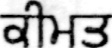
ਕੀਮਤ
